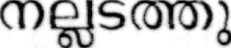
നല്ലടത്തു
